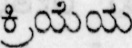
ಕ್ರಿಯೆಯ
